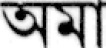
অমা
